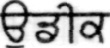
ਉਡੀਕ
